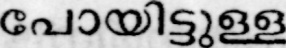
പോയിട്ടുള്ള
